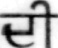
ਦੀ
